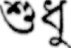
শুধু
